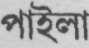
পাইলা
